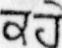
ਕਹੇ
